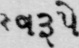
સ્વરૂપે
